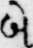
બે
